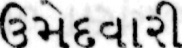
ઉમેદવારી
